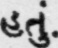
હતું.
